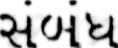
સંબંધ
